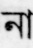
না
